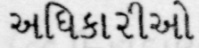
અધિકારીઓ
